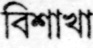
বিশাখা
